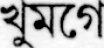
খুমগে
